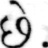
છે.
